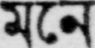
মনে
